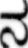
ನ
